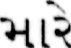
મારે
